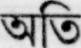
অতি
